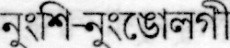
নুংশি-নুংঙোলগী
